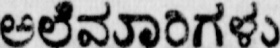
ಅಲೆಮಾರಿಗಳು
